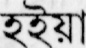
হইয়া
